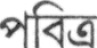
পবিত্র
